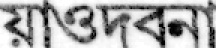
য়াওদবনা
